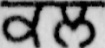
ਕਲ
